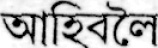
আহিবলৈ
